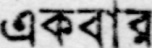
একবার
